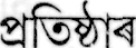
প্রতিষ্ঠাৰ
